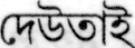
দেউতাই
